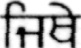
ਜਿਥੇ
